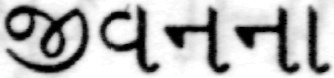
જીવનના
